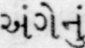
અંગેનું
